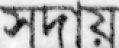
সদায়
